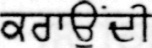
ਕਰਾਉਂਦੀ
